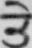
ਤੇ
